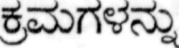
ಕ್ರಮಗಳನ್ನು
